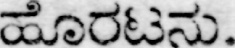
ಹೊರಟನು.
